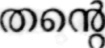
തന്റെ
